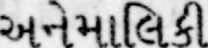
અનેમાલિકી
